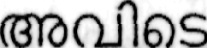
അവിടെ
